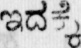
ಇದಕ್ಕೆ
